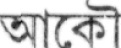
আকৌ
